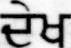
ਦੇਖ
